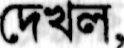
দেখল,
